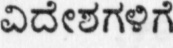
ವಿದೇಶಗಳಿಗೆ
